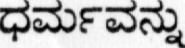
ಧರ್ಮವನ್ನು
